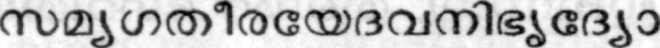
സമ്യഗതീരയേദവനിഭൃദ്യോ
